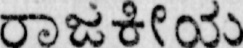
ರಾಜಕೀಯ
